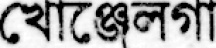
খোঞ্জেলগা
